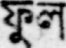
ফুল
